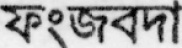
ফংজবদা
